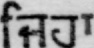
ਜਿਹਾ
